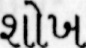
શોખ
